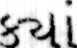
ક્યાં
